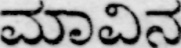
ಮಾವಿನ
